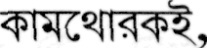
কামথোরকই,
